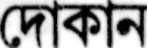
দোকান
